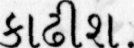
કાઢીશ.
